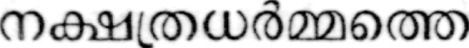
നക്ഷത്രധര്‍മ്മത്തെ
